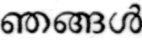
ഞങ്ങള്‍
